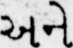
અને
